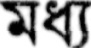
মধ্য
